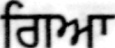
ਗਿਆ
